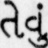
તેવું
